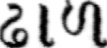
ઢાળ
